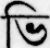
ভি
